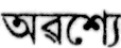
অৱশ্যে
